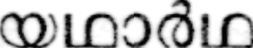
യഥാര്‍ഥ
